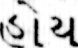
હોય
